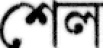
শেল
